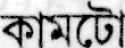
কামটো
